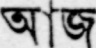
আজ
